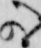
જે
